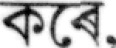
কৰে,
